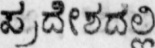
ಪ್ರದೇಶದಲ್ಲಿ
